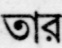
তার
